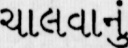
ચાલવાનું
